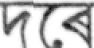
দৰে
